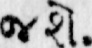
જશે.
